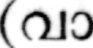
(വാ
